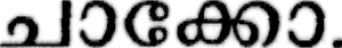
ചാക്കോ.
